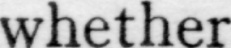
whether
